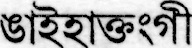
ঙাইহাক্তংগী
